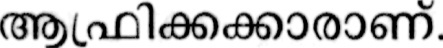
ആഫ്രിക്കക്കാരാണ്.
